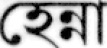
হেন্না
